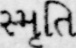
સ્મૃતિ
